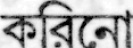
করিনো
